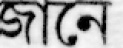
জানে
